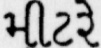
મીટરે
